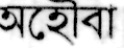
অহৌবা
